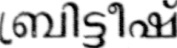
ബ്രിട്ടീഷ്
